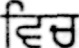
ਵਿਚ
